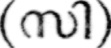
(സി)
